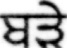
ਬੜੇ
